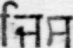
ਜਿਸ
